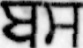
ਬਸ
